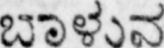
ಬಾಳುವ
